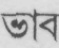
ভাব
